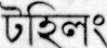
টহিলং
